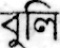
বুলি
